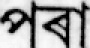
পৰা
